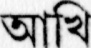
আখি
